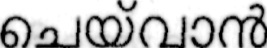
ചെയ്വാന്‍
